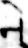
ને
